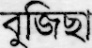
বুজিছা
